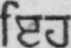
ਇਹ
